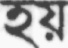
হয়
